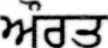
ਔਰਤ
